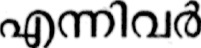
എന്നിവര്‍
